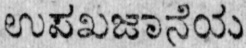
ಉಪಖಜಾನೆಯ
